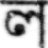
ল
